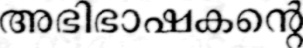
അഭിഭാഷകന്റെ
